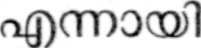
എന്നായി
